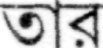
তার
